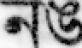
নঙ
